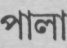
পালা
